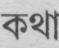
কথা
